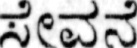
ಸೇವನೆ
